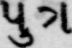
પુત્ર
